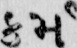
કર્મ
